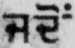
ਜਦੋਂ
